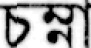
চম্না
